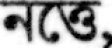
নত্তে,
